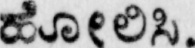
ಹೋಲಿಸಿ.
